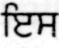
ਇਸ
